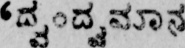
‘ದ್ವಂದ್ವಮಾನ
